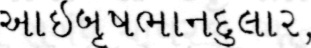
આઈબૃષભાનદુલાર,
